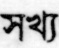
সখ্য
